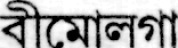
বীমোলগা
